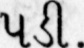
પડી.
